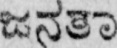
ಜನತಾ
